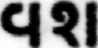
વશ
